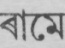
ৰামে
